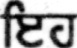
ਇਹ
